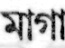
মাগা
